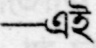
–এই
